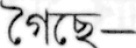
গৈছে-
